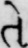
તે
